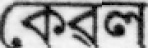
কেৱল
